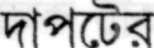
দাপটের
